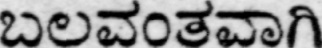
ಬಲವಂತವಾಗಿ
